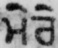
ਮੇਰੇ
